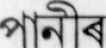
পানীৰ
